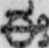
ಈ
